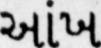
આંખ
